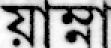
য়াম্না
